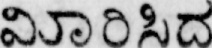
ಮೀರಿಸಿದ
